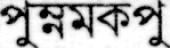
পুম্নমকপু
